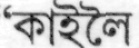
"কাইলৈ
